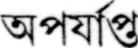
অপর্যাপ্ত
